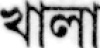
খালা
